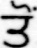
ਤੋਂ
